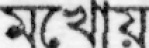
মখোয়
